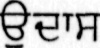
ਉਦਾਸ
